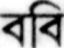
ববি
